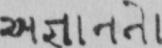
અજ્ઞાનનો
